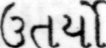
ઉતર્યો
